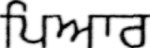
ਪਿਆਰ
